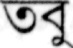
তবু
